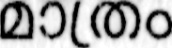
മാത്രം
